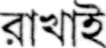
রাখাই
